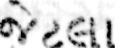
જેટલા
